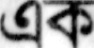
এক
